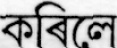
কৰিলে
